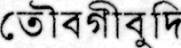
তৌবগীবুদি
